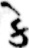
કે
